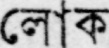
লোক
